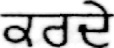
ਕਰਦੇ
